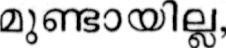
മുണ്ടായില്ല,
